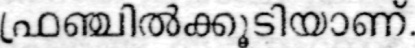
ഫ്രഞ്ചില്‍ക്കൂടിയാണ്.
